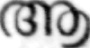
ആ
